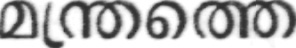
മന്ത്രത്തെ
